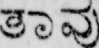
ತಾವು
